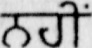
ਨਹੀਂ
